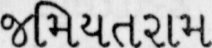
જમિયતરામ
